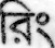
রিং
